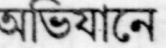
অভিযানে
